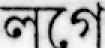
লগে
